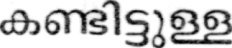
കണ്ടിട്ടുള്ള
